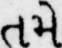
તમે
